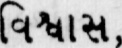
વિશ્વાસ,
